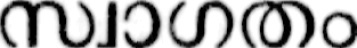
സ്വാഗതം
